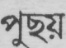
পুছয়
